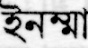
ইনম্মা
